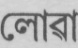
লোৱা
